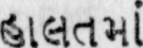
હાલતમાં
